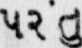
પરંતુ
